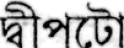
দ্বীপটো
